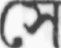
সে
